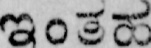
ಇಂತಹ
